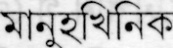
মানুহখিনিক
